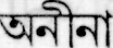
অনীনা
